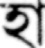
হা
